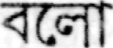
বলো
